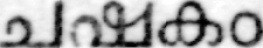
ചഷകം
